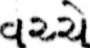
વચ્ચે
